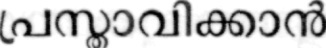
പ്രസ്താവിക്കാന്‍
